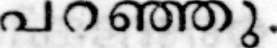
പറഞ്ഞു.
